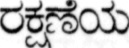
ರಕ್ಷಣೆಯ
